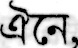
ঐনে,
